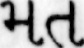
મત
